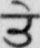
ਤੇ
